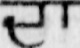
ਦਾ
